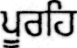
ਪੂਰਹਿ
